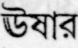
ঊষার
